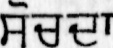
ਸੋਚਦਾ
